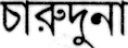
চারুদুনা
